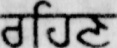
ਰਹਿਣ
